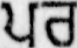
ਪਰ
